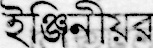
ইঞ্জিনীয়র
